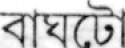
বাঘটো
